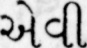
એવી
